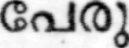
പേരു
